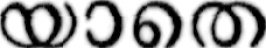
യാതെ
